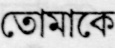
তোমাকে
